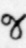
જ
